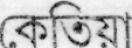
কেতিয়া
